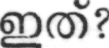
ഇത്?
